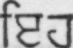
ਇਹ
